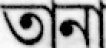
তানা
